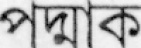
পদ্মাক
